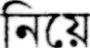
নিয়ে
